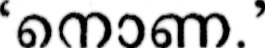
‘നൊണ.’
